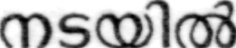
നടയില്‍
